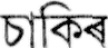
চাকিৰ
